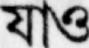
যাও
